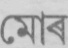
মোৰ
